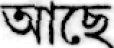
আছে
